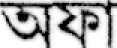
অফা
